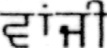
ਵਾਂਜੀ
